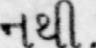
નથી.
